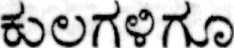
ಕುಲಗಳಿಗೂ
